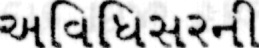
અવિધિસરની
